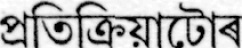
প্রতিক্রিয়াটোৰ
